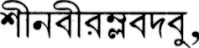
শীনবীরম্লবদবু,
